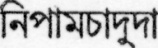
নিপামচাদুদা
